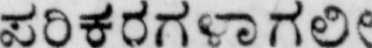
ಪರಿಕರಗಳಾಗಲೀ
